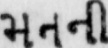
મનની
